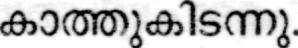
കാത്തുകിടന്നു.
